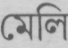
মেলি
